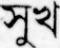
সুখ
